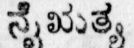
ನೈಋತ್ಯ
